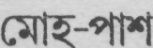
মোহ-পাশ
